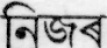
নিজৰ
